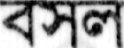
বসল
